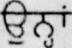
ਉਨ੍ਹਾਂ
